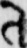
તે
